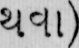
થવા
